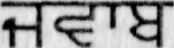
ਜਵਾਬ
